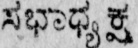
ಸಭಾಧ್ಯಕ್ಷ
